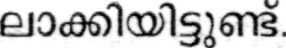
ലാക്കിയിട്ടുണ്ട്.
